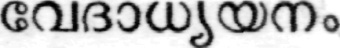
വേദാധ്യയനം
